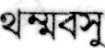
থম্মবসু
